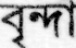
বৃন্দা
